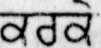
ਕਰਕੇ
